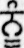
ਨੂੰ
